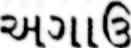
અગાઉ
